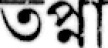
তপ্না
